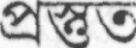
প্রস্তুত
